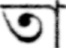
তা
